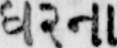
ઘરના
